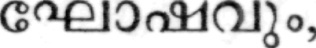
ഘോഷവും,
